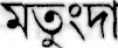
মতুংদা
